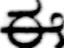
ಈ
